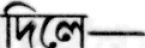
দিলে-
